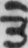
ਤੇ
